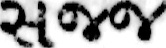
સજ્જ
